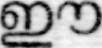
ഈ
